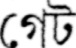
গেট
